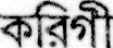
করিগী
